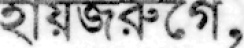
হায়জরুগে,
